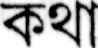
কথা
